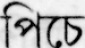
পিচে
